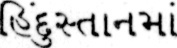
હિંદુસ્તાનમાં
